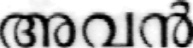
അവന്‍
